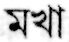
মখা
